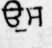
ਉਸ
